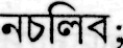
নচলিব;
